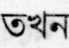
তখন
